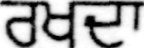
ਰਖਦਾ
